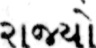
રાજ્યો
